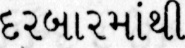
દરબારમાંથી
